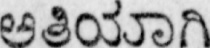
ಅತಿಯಾಗಿ
